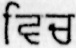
ਵਿਚ
